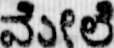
ಮೇಲೆ
